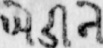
ખેડીને
